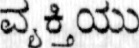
ವ್ಯಕ್ತಿಯು
